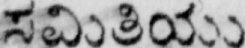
ಸಮಿತಿಯು
